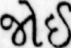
જોઈ
